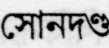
সোনদণ্ড
